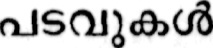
പടവുകള്‍
